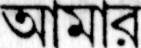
আমার
